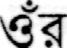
ওঁর
